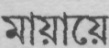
মায়ায়ে
